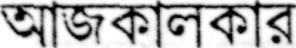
আজকালকার
